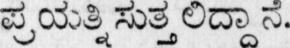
ಪ್ರಯತ್ನಿಸುತ್ತಲಿದ್ದಾನೆ.
